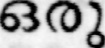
ഒരു
